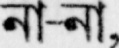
না-না,
